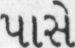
પાસે
